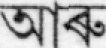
আৰু
